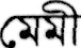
মেমী
